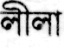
লীলা
